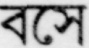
বসে
